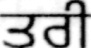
ਤਰੀ
